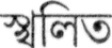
স্খলিত
